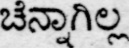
ಚೆನ್ನಾಗಿಲ್ಲ
